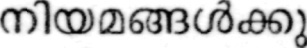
നിയമങ്ങള്‍ക്കു
